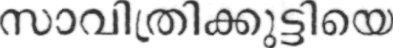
സാവിത്രിക്കുട്ടിയെ
